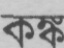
কঙ্ক
